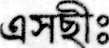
এসছীঃ
